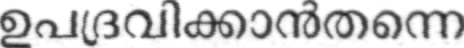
ഉപദ്രവിക്കാന്‍തന്നെ
